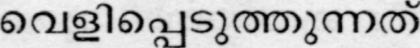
വെളിപ്പെടുത്തുന്നത്
